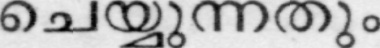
ചെയ്യുന്നതും
